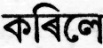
কৰিলে
